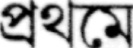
প্রথমে
